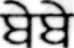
ਬੇਬੇ
